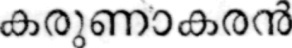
കരുണാകരന്‍
